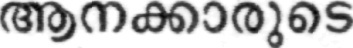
ആനക്കാരുടെ
